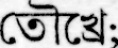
তৌখ্রে;
